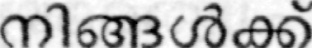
നിങ്ങള്‍ക്ക്
